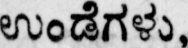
ಉಂಡೆಗಳು,
